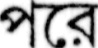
পরে
